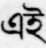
এই
